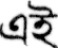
এই
